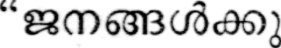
"ജനങ്ങള്‍ക്കു
